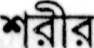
শরীর
